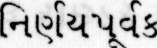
નિર્ણયપૂર્વક
